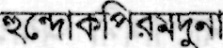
হুন্দোকপিরমদুনা
